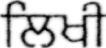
ਲਿਖੀ
